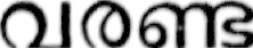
വരണ്ട
